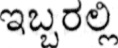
ಇಬ್ಬರಲ್ಲಿ
